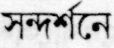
সন্দর্শনে
